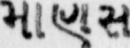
માણસ
